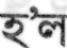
হ'ল
